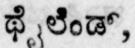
ಥೈಲೆಂಡ್,
